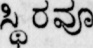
ಸ್ಥಿರವೂ
